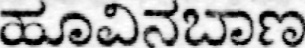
ಹೂವಿನಬಾಣ
